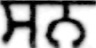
ਸਨ
